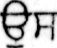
ਉਸ
